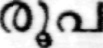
രൂപ
